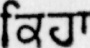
ਕਿਹਾ
